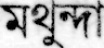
মথুন্দা
